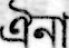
ঐনা
